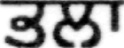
ਭਲਾ
